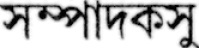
সম্পাদকসু
